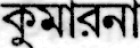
কুমারনা
